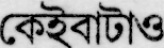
কেইবাটাও
